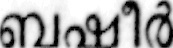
ബഷീര്‍
